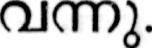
വന്നു.
